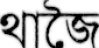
থাজৈ
